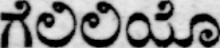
ಗೆಲಿಲಿಯೊ
